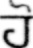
ਹੋ
